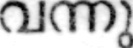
വന്നു
